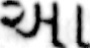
આ
